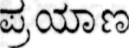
ಪ್ರಯಾಣ
